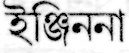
ইঞ্জিননা
